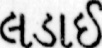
લડાઈ
